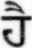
ਹੈ
